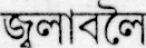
জ্বলাবলৈ
